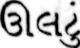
ઊલટું
